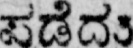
ಪಡೆದು
